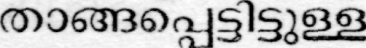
താങ്ങപ്പെട്ടിട്ടുള്ള
